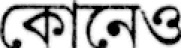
কোনেও
